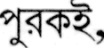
পুরকই,
